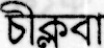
চীক্লবা
